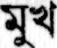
মুখ
